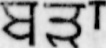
ਬੜਾ
